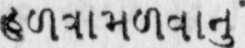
હળવામળવાનું
